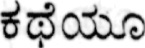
ಕಥೆಯೂ
